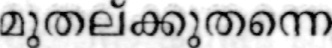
മുതല്ക്കുതന്നെ
